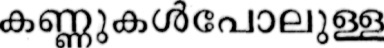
കണ്ണുകള്‍പോലുള്ള
